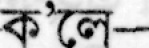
ক'লে-
